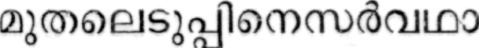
മുതലെടുപ്പിനെസര്‍വഥാ
